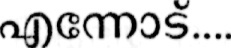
എന്നോട്....
